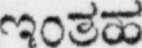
ಇಂತಹ
